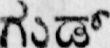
ಗುಡ್
